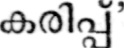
കരിപ്പ്'
